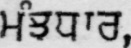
ਮੰਝਧਾਰ,
